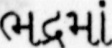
ભદ્રમાં
